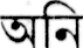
অনি
